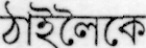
ঠাইলৈকে
